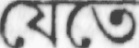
যেতে
